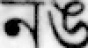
নঙ
